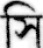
সি
